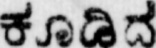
ಕೂಡಿದ
